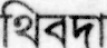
থিবদা
